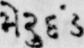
મેરુદંડ
